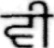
ਵੀ
